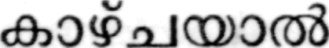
കാഴ്ചയാല്‍
